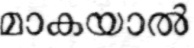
മാകയാല്‍
